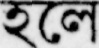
হলে
